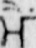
ਮੈਂ
